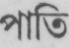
পাতি
